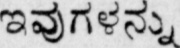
ಇವುಗಳನ್ನು
